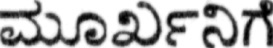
ಮೂರ್ಖನಿಗೆ
